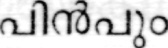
പിന്‍പും
